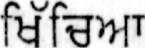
ਖਿੱਚਿਆ
